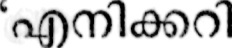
‘എനിക്കറി
